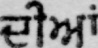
ਦੀਆਂ
